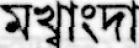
মখ্বাংদা
